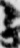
કે
